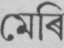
মেৰি
